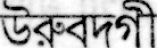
উরুবদগী
